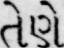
તેણે
